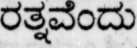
ರತ್ನವೆಂದು
